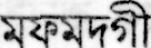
মফমদগী
